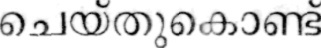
ചെയ്തുകൊണ്ട്
